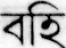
বহি
